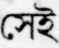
সেই
